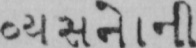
વ્યસનોની
